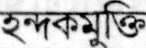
হন্দকমুক্তি
